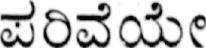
ಪರಿವೆಯೇ
